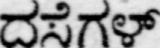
ದಸೆಗಳ್
